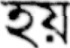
হয়
